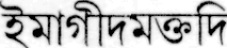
ইমাগীদমক্তদি
